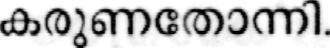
കരുണതോന്നി.
